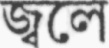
জ্বলে
